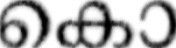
കൊ
